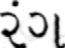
રંગ
